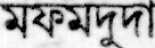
মফমদুদা
